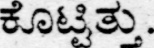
ಕೊಟ್ಟಿತ್ತು.
